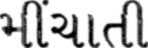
મીંચાતી
